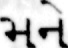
મને
